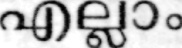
എല്ലാം
